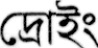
দ্রোইং
